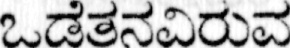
ಒಡೆತನವಿರುವ
